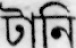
টানি
